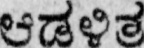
ಆಡಳಿತ
